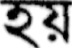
হয়
